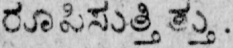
ರೂಪಿಸುತ್ತಿತ್ತು.
